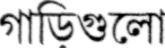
গাড়িগুলো
